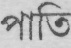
পাতি
